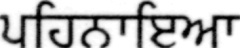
ਪਹਿਨਾਇਆ
